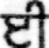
ਈ
